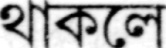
থাকলে
